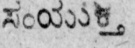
ಸಂಯುಕ್ತ
